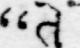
"તેં
